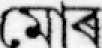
মোৰ
